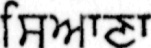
ਸਿਆਣਾ
